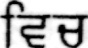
ਵਿਚ
